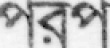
পরপ
